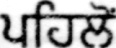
ਪਹਿਲੋਂ
